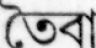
তৈবা
